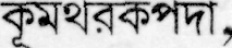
কূমথরকপদা,
